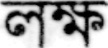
লক্ষ
